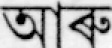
আৰু
